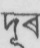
দূৰ
